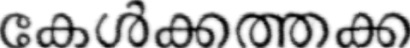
കേള്‍ക്കത്തക്ക
